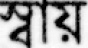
স্বায়
